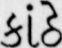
કાંઠે
